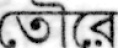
তৌরে
